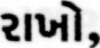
રાખો,
